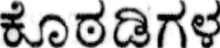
ಕೊಠಡಿಗಳ
